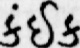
કંઈક
